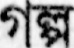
গল্প
